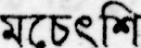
মচেৎশি
